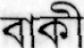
বাকী
